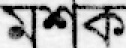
মশক
